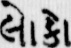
લોકો
